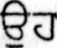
ਉਹ
